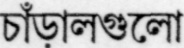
চাঁড়ালগুলো
